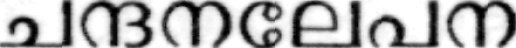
ചന്ദനലേപന
